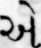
એ
